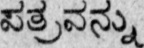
ಪತ್ರವನ್ನು
